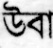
উবা
